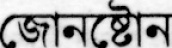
জোনষ্টোন
